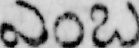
ಎಂಬ
